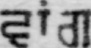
ਵਾਂਗ
